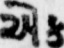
એક
